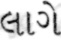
લાગે
